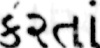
કરતાં
